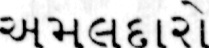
અમલદારો
